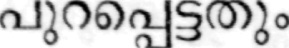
പുറപ്പെട്ടതും
